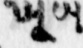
ખૂબ
